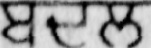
ਬਦਲ
